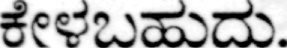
ಕೇಳಬಹುದು.
